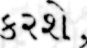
કરશે,
